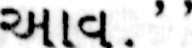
આવ."
